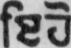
ਇਹੋ
